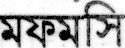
মফমসি
